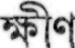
ক্ষীণ
